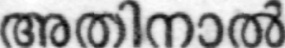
അതിനാല്‍
